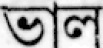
ভাল
